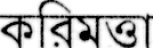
করিমত্তা
